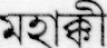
মহাক্কী
